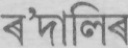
ৰ'দালিৰ
